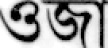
ওজা
